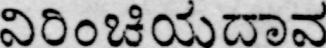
ವಿರಿಂಚಿಯದಾವ
